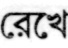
রেখে
